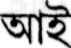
আই
